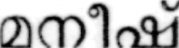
മനീഷ്
